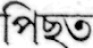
পিছত
